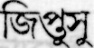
জিপ্তুসু
